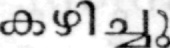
കഴിച്ചു
